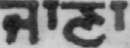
ਜਾਣਾ
